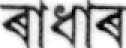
ৰাধাৰ
